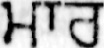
ਮਾਰ
